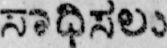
ಸಾಧಿಸಲು
